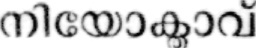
നിയോക്താവ്
